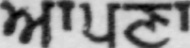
ਆਪਣਾ
